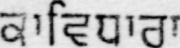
ਕਾਵਿਧਾਰਾ
